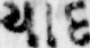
યાદ
